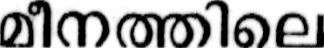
മീനത്തിലെ
